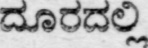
ದೂರದಲ್ಲಿ
